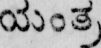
ಯಂತ್ರ
